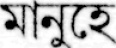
মানুহে
